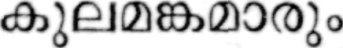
കുലമങ്കമാരും
